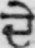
ਦੇ
